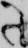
તે
